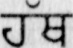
ਹੱਥ
